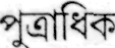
পুত্রাধিক
